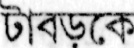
টাবড়কে
